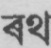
ৰথ
